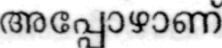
അപ്പോഴാണ്
